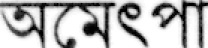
অমেৎপা
